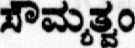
ಸೌಮ್ಯತ್ವಂ
